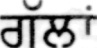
ਗੱਲਾਂ
